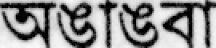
অঙাঙবা
